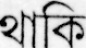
থাকি
